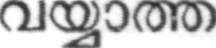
വയ്യാത്ത
